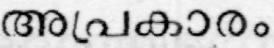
അപ്രകാരം
